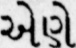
એણે
